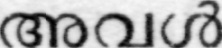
അവള്‍
